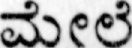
ಮೇಲೆ
